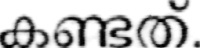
കണ്ടത്.
